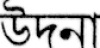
উদনা
